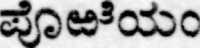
ಪೊಱೆಯಂ
